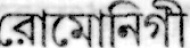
রোমোনিগী
